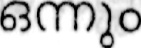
ഒന്നും
